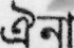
ঐনা
